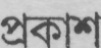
প্ৰকাশ
